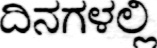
ದಿನಗಳಲ್ಲಿ
